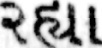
રહ્યા
